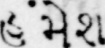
હંમેશ
